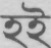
হই
